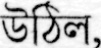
উঠিল,
